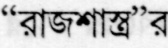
“রাজশাস্ত্র”র
